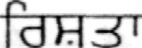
ਰਿਸ਼ਤਾ
